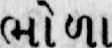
ભોળા
